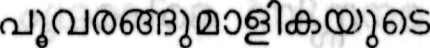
പൂവരങ്ങുമാളികയുടെ
